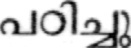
പഠിച്ചു
